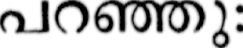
പറഞ്ഞു:
